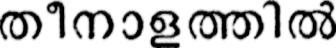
തീനാളത്തില്‍
